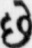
છે
